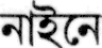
নাইনে
